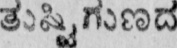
ತುಷ್ಟಿಗುಣದ
